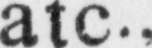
atc.,
